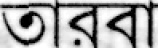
তারবা
